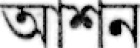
আশন
